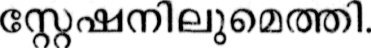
സ്റ്റേഷനിലുമെത്തി.
